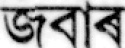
জবাৰ
